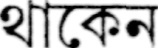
থাকেন
